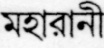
মহারানী
